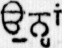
ਉਨ੍ਹਾਂ
